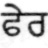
ਫੇਰ
